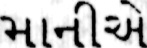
માનીએ
